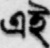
এই
